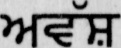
ਅਵੱਸ਼
